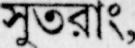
সুতরাং,
